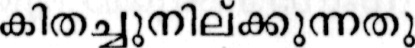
കിതച്ചുനില്ക്കുന്നതു
